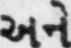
અને
